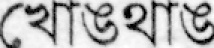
খোঙথাঙ
